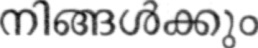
നിങ്ങള്‍ക്കും
